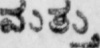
ಮತ್ತು
